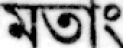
মতাং
